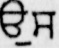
ਉਸ
